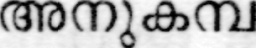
അനുകമ്പ
